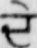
ਦੇ
